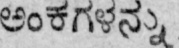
ಅಂಕಗಳನ್ನು
